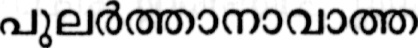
പുലര്‍ത്താനാവാത്ത
